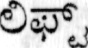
ಲಿಫ್ಟ್
